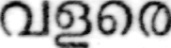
വളരെ
